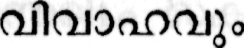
വിവാഹവും
